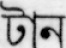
টান
